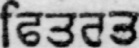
ਫਿਤਰਤ
